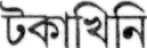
টকাখিনি
